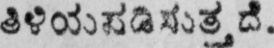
ತಿಳಿಯಪಡಿಸುತ್ತದೆ.
